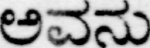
ಅವನು
